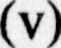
(v)
